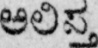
ಅಲಿಪ್ತ
